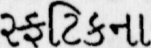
સ્ફટિકના
